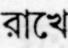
রাখে
